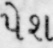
પેશ
